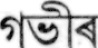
গভীৰ
